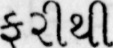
ફરીથી
